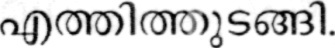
എത്തിത്തുടങ്ങി.
